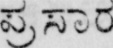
ಪ್ರಸಾರ
